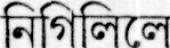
নিগিলিলে
